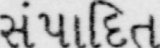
સંપાદિત
